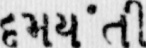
દમયંતી
